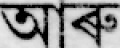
আৰু
